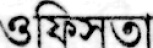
ওফিসতা
